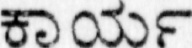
ಕಾರ್ಯ
